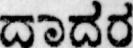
ದಾದರ
